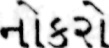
નોકરો
